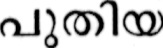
പുതിയ
